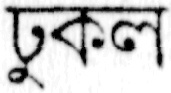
ঢুকল
